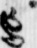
હું
